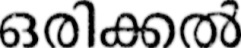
ഒരിക്കല്‍
